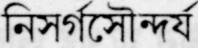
নিসর্গসৌন্দর্য
